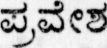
ಪ್ರವೇಶ
